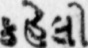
કહેલી
